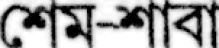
শেম-শাবা
